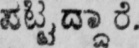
ಪಟ್ಟಿದ್ದಾರೆ.
